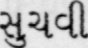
સુચવી
